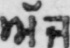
ਅੱਜ
